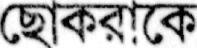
ছোকরাকে
